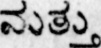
ಮತ್ತು
